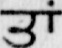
ਤਾਂ
